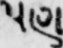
પણ
